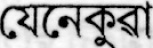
যেনেকুৱা
